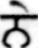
ਨੇ
